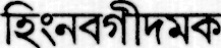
হিংনবগীদমক
